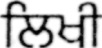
ਲਿਖੀ
